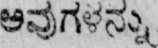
ಅವುಗಳನ್ನು
